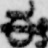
ಈ
